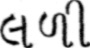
લળી
